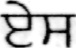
ਏਸ
